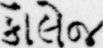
કૅ।લેજ
